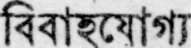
বিবাহযোগ্য
